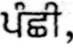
ਪੰਛੀ,
